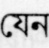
যেন
